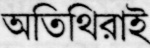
অতিথিরাই
